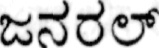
ಜನರಲ್
